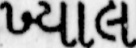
ખ્યાલ
